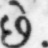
છે.
